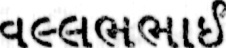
વલ્લભભાઈ
